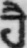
ਹੈ
